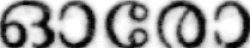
ഓരോ
